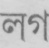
লগ
